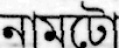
নামটো
